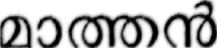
മാത്തന്‍
